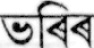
ভৰিৰ
